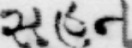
સહન
